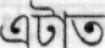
এটাত
